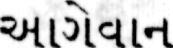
આગેવાન
